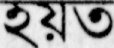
হয়ত
